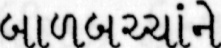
બાળબચ્ચાંને
